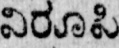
ವಿರೂಪಿ
